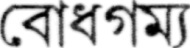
বোধগম্য
